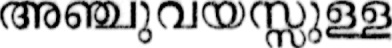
അഞ്ചുവയസ്സുള്ള
